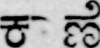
ಕಾಣೆ
